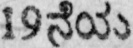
19ನೆಯ
